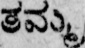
ತಮ್ಮ
